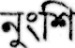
নুংশি
